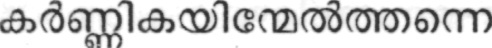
കര്‍ണ്ണികയിന്മേല്‍ത്തന്നെ
